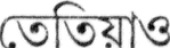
তেতিয়াও
